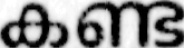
കണ്ട
